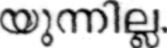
യുന്നില്ല.
